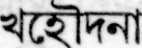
খহৌদনা
